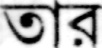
তার
